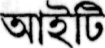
আইটি
